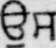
ਉਸ
